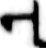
ન
